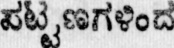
ಪಟ್ಟಣಗಳಿಂದ
